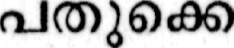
പതുക്കെ
